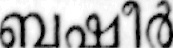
ബഷീര്‍
